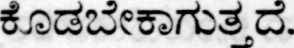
ಕೊಡಬೇಕಾಗುತ್ತದೆ.
